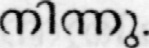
നിന്നു.
